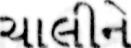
ચાલીને
